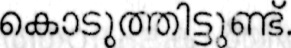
കൊടുത്തിട്ടുണ്ട്.
